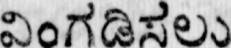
ವಿಂಗಡಿಸಲು
